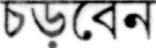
চড়বেন
